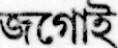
জগোই
